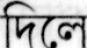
দিলে
